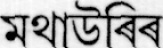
মথাউৰিৰ
